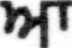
ਆ
